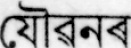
যৌৱনৰ
